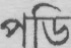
পড়ি
